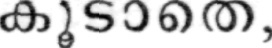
കൂടാതെ,
